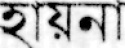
হায়না
